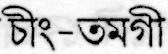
চীং-তমগী
